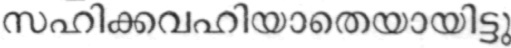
സഹിക്കവഹിയാതെയായിട്ടു
